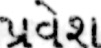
પ્રવેશ
